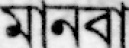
মানবা
